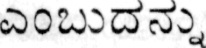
ಎಂಬುದನ್ನು
